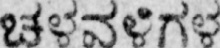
ಚಳವಳಿಗಳ
